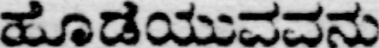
ಹೊಡಯುವವನು
